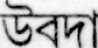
উবদা
